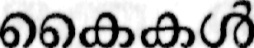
കൈകള്‍
